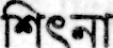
শিৎনা
